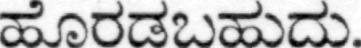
ಹೊರಡಬಹುದು.
